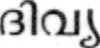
ദിവ്യ
